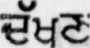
ਦੱਖਣ
